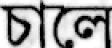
চালে
